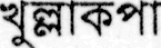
খুল্লাকপা
